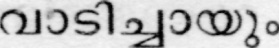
വാടിച്ചായും
